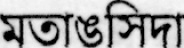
মতাঙসিদা
